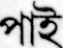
পাই
